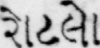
રોટલો
